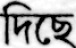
দিছে
